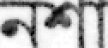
নশা
